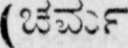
(ಚರ್ಮ
